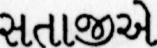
સતાજીએ
